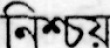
নিশ্চয়
